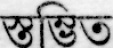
স্তম্ভিত
